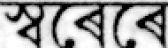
স্বৰেৰে
